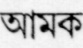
আমক
